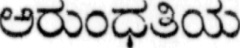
ಅರುಂಧತಿಯ
